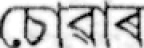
চোৱাৰ
